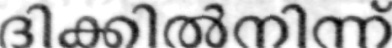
ദിക്കില്‍നിന്ന്
